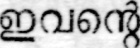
ഇവന്റെ
